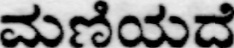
ಮಣಿಯದೆ
